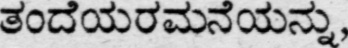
ತಂದೆಯರಮನೆಯನ್ನು
